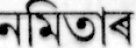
নমিতাৰ
